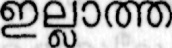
ഇല്ലാത്ത
